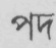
পদ
